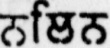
ਨਲਿਨ
